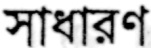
সাধারণ
